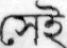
সেই
